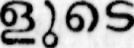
ളുടെ
